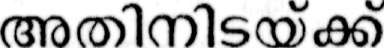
അതിനിടയ്ക്ക്
